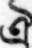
ঐ
